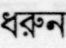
ধরুন
